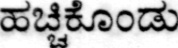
ಹಚ್ಚಿಕೊಂಡು
